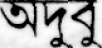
অদুবু
